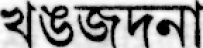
খঙজদনা
